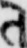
તે
